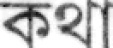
কথা
